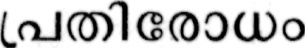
പ്രതിരോധം
